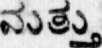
ಮತ್ತು
